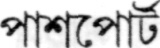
পাশপোর্ট
